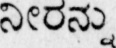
ನೀರನ್ನು
